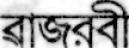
ৱাজরবী
